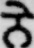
ਨੇ
